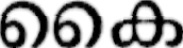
കൈ
